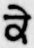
ਕੇ
